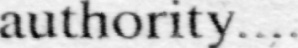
authority....
